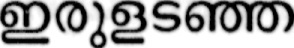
ഇരുളടഞ്ഞ
